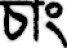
চাং
